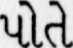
પોતે
